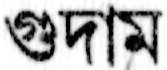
গুদাম
